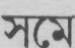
সমে
